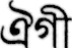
ঐগী
